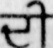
ਦੀ
